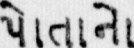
પોતાનો
